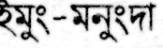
ইমুং-মনুংদা
